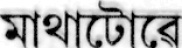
মাথাটোৱে
